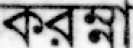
করম্না
